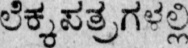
ಲೆಕ್ಕಪತ್ರಗಳಲ್ಲಿ
